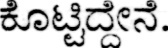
ಕೊಟ್ಟಿದ್ದೇನೆ.
